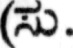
(ಸು.
